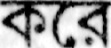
করে
